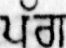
ਪੱਗ
